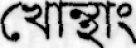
খোন্থাং
